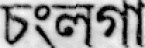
চংলগা
